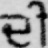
ਦੀ
